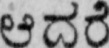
ಆದರೆ
